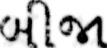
બીજા
